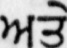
ਅਤੇ
